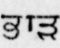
ਭਾੜ
